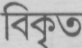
বিকৃত
